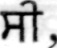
ਸੀ,
